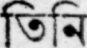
তিনি
